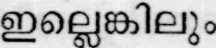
ഇല്ലെങ്കിലും
